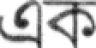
এক
